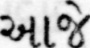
આજે
